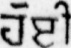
ਹੋਈ
